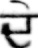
ਦੇ
